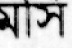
মসি
